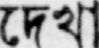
দেখা
